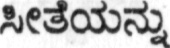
ಸೀತೆಯನ್ನು
